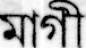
মাগী
